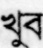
খুব
